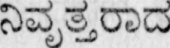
ನಿವೃತ್ತರಾದ
